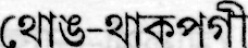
থোঙ-থাকপগী
